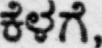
ಕೆಳಗೆ,
